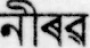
নীৰৱ
